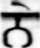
ਨੇ
